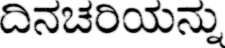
ದಿನಚರಿಯನ್ನು
